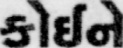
કોઈને
